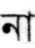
না
